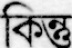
কিন্তু
